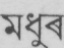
মধুৰ
